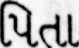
પિતા
